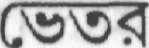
ভেতর
